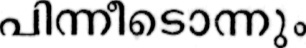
പിന്നീടൊന്നും
